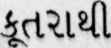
કૂતરાથી
